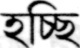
হচ্ছি
